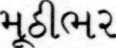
મૂઠીભર
